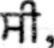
ਸੀ,
